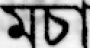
মচা
